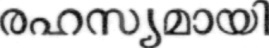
രഹസ്യമായി
